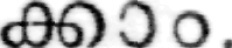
ക്കാം.
